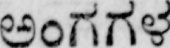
ಅಂಗಗಳ
